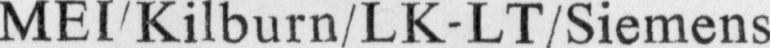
MEI/Kilburn/LK-LT/Siemens
